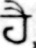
ਹੈ,
